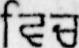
ਵਿਚ
